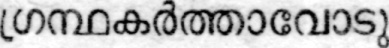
ഗ്രന്ഥകര്‍ത്താവോടു
